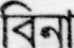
বিনা
